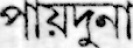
পায়দুনা
